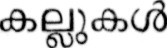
കല്ലുകള്‍
